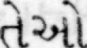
તેઓ
